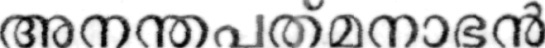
അനന്തപത്മനാഭന്‍
